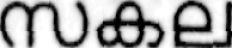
സകല
